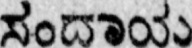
ಸಂದಾಯ
